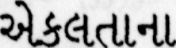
એકલતાના
